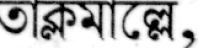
তাক্লমাল্লে,
